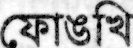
ফোঙখি
